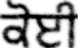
ਕੋਈ
